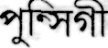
পুন্সিগী
